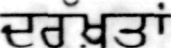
ਦਰੱਖ਼ਤਾਂ
